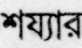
শয্যার
